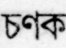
চণক
